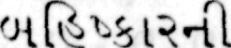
બહિષ્કારની
